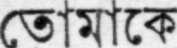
তোমাকে
